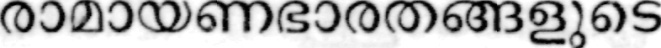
രാമായണഭാരതങ്ങളുടെ
